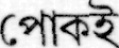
পোকই
